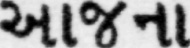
આજના
